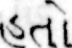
હતો
